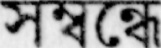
সম্বন্ধে
